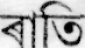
ৰাতি
